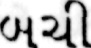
બચી
